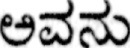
ಅವನು
